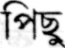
পিছু
